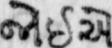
જોઈએ
